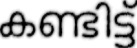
കണ്ടിട്ട്
